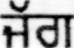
ਜੱਗ
